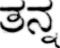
ತನ್ನ
